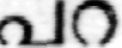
പറ
